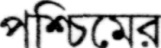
পশ্চিমের
